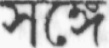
সঙ্গে
